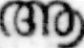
ആ
